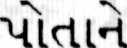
પોતાને
